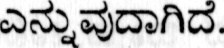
ಎನ್ನುವುದಾಗಿದೆ.
